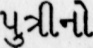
પુત્રીનો
